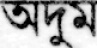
অদুম
